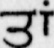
ਤਾਂ
